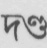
দণ্ড
